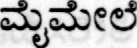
ಮೈಮೇಲೆ
